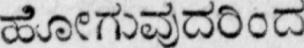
ಹೋಗುವುದರಿಂದ
